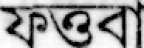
ফত্তবা
